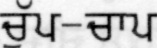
ਚੁੱਪ-ਚਾਪ
